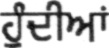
ਹੁੰਦੀਆਂ
